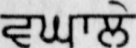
ਵਘਾਲੇ
